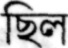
ছিল
